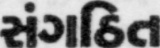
સંગઠિત
